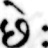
છેઃ
